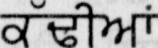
ਕੱਢੀਆਂ
